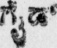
ಗೈಡ್
